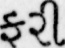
ફરી
